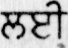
ਲਈ
